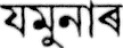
যমুনাৰ
